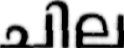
ചില
